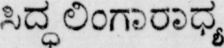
ಸಿದ್ಧಲಿಂಗಾರಾಧ್ಯ
